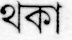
থকা
